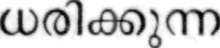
ധരിക്കുന്ന
